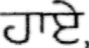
ਹਾਏ,
